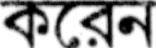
করেন
